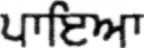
ਪਾਇਆ
